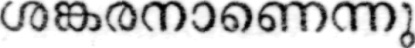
ശങ്കരനാണെന്നു
